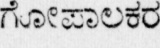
ಗೋಪಾಲಕರ
